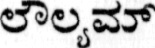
ಲೌಲ್ಯಮ್
